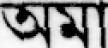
অমা
